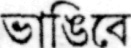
ভাঙিবে
